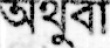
অথুবা
